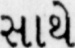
સાથે
